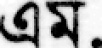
এম.
